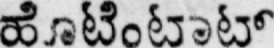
ಹೊಟೆಂಟಾಟ್
